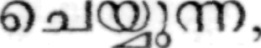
ചെയ്യുന്ന,
